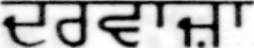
ਦਰਵਾਜ਼ਾ
